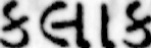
કલાક
